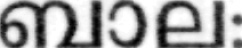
ബാല:
